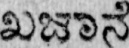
ಖಜಾನೆ
